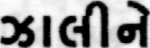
ઝાલીને
